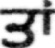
ਤਾਂ
